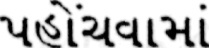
પહોંચવામાં
